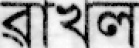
ৱাখল
